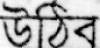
উঠিব
